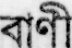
বাণী
